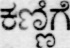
ಕಣ್ಣಿಗೆ
